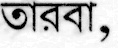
তারবা,
